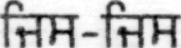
ਜਿਸ-ਜਿਸ
